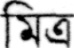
মিত্র
